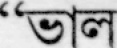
"ভাল
